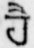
ਹੈ
